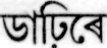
ডাঢ়িৰে
